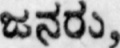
ಜನರು,
